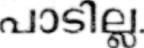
പാടില്ല.
